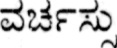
ವರ್ಚಸ್ಸು
